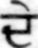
ਦੇ
